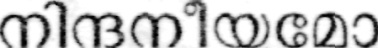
നിന്ദനീയമോ
